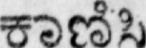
ಕಾಣಿಸಿ
